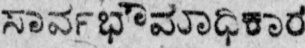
ಸಾರ್ವಭೌಮಾಧಿಕಾರ
